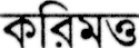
করিমত্ত
